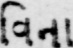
વિના
